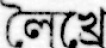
লৈখ্রে
